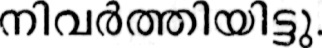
നിവര്‍ത്തിയിട്ടു.
